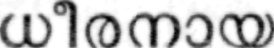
ധീരനായ
